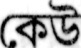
কেউ
